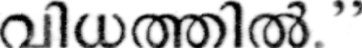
വിധത്തില്‍."
